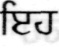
ਇਹ
